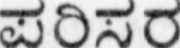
ಪರಿಸರ
